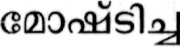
മോഷ്ടിച്ച
